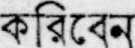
করিবেন
